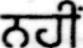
ਨਹੀਂ
